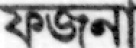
ফজনা
